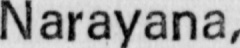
Narayana,
